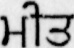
ਮੀਤ
